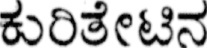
ಕುರಿತೇಟಿನ
